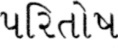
પરિતોષ
